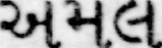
અમલ
